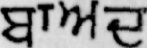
ਬਾਅਦ
